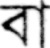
বা
